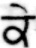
ਕੇ
